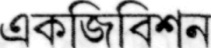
একজিবিশন
